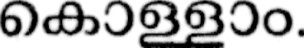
കൊള്ളാം.
